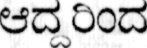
ಆದ್ದರಿಂದ
